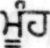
ਮੂੰਹ
